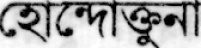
হোন্দোক্তুনা
